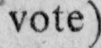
vote)
